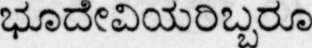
ಭೂದೇವಿಯರಿಬ್ಬರೂ
